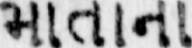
માતાના
